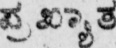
ಪ್ರಖ್ಯಾತ
